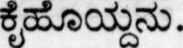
ಕೈಹೊಯ್ದನು.
